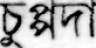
চুপ্পদা
